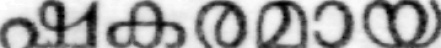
ഷകരമായ
